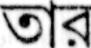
তার
